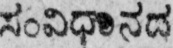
ಸಂವಿಧಾನದ
